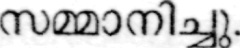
സമ്മാനിച്ചു.
